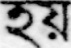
হয়
